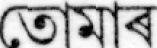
তোমাৰ
